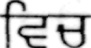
ਵਿਚ
